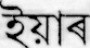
ইয়াৰ
